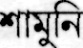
শামুনি
